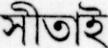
সীতাই
